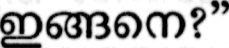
ഇങ്ങനെ?”
